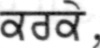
ਕਰਕੇ,
